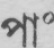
পা
